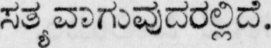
ಸತ್ಯವಾಗುವುದರಲ್ಲಿದೆ.
